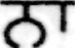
ਨਾ
